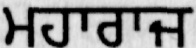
ਮਹਾਰਾਜ
